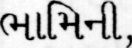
ભામિની,
